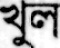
খুল
